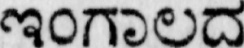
ಇಂಗಾಲದ
